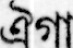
ঐগা
